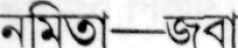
নমিতা-জবা
